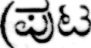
(ಪುಟ
